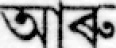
আৰু
